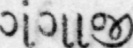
ગંગાજી
